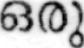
ഒരു
